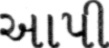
આપી
